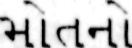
મોતનો
